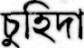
চুহিদা
